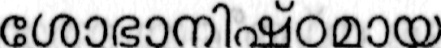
ശോഭാനിഷ്ഠമായ
